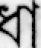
ধা
